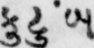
કુટુંબ
